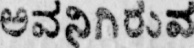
ಅವನಿಗಿರುವ
